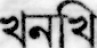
খনখি
